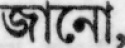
জানো,
